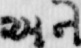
અને
